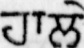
ਹਾਲੇ
